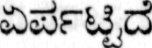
ಏರ್ಪಟ್ಟಿದೆ
